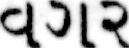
વગર
